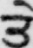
ਤੇ
